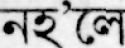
নহ'লে
